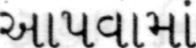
આપવામાં
